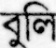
বুলি
